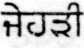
ਜੇਹੜੀ
